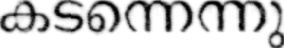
കടന്നെന്നു
